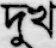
দুখ
